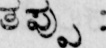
ತಪ್ಪು:
